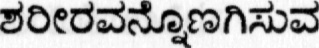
ಶರೀರವನ್ನೊಣಗಿಸುವ
